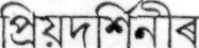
প্রিয়দৰ্শিনীৰ
